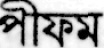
পীফম
